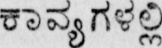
ಕಾವ್ಯಗಳಲ್ಲಿ
